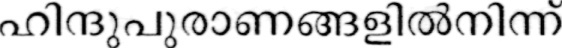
ഹിന്ദുപുരാണങ്ങളില്‍നിന്ന്
